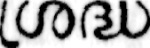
ശ്രദ്ധ
